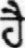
ਹੈ
